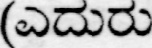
(ಎದುರು
